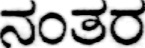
ನಂತರ
